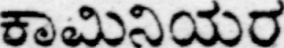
ಕಾಮಿನಿಯರ
